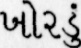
ખોરડું
